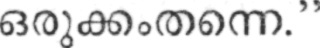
ഒരുക്കംതന്നെ."
